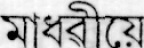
মাধৱীয়ে
